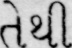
તેથી
